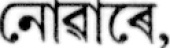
নোৱাৰে,
